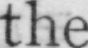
the
